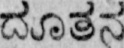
ದೂತನ
